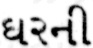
ઘરની
